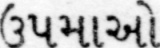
ઉપમાઓ
